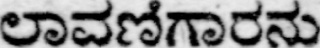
ಲಾವಣಿಗಾರನು
